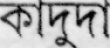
কাদুদা
